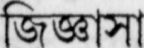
জিজ্ঞাসা
